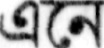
এনে
